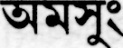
অমসুং
